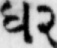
ધર
